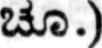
ಚೂ.)
